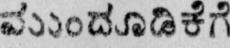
ಮುಂದೂಡಿಕೆಗೆ
